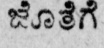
ಜೊತೆಗೆ
